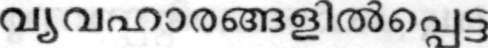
വ്യവഹാരങ്ങളില്‍പ്പെട്ട
